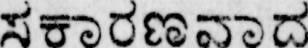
ಸಕಾರಣವಾದ
